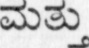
ಮತ್ತು
